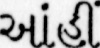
આંહીં
